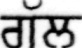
ਗੱਲ
